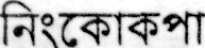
নিংকোকপা
